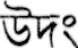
উদং
